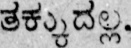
ತಕ್ಕುದಲ್ಲ.
